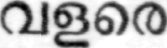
വളരെ
